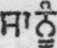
ਸਾਨੂੰ
